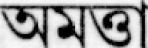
অমত্তা
